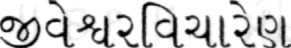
જીવેશ્વરવિચારેણ
